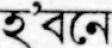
হ'বনে
